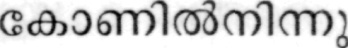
കോണില്‍നിന്നു
